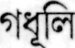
গধূলি
